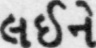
લઈને
